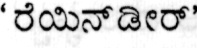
‘ರೆಯಿನ್ ಡೀರ್'
